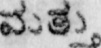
ಮತ್ತು
